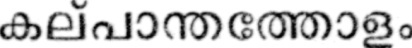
കല്പാന്തത്തോളം
